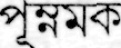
পূম্নমক
